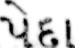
પેદા
